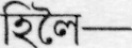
হিলৈ-
